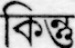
কিন্তু
